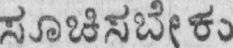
ಸೂಚಿಸಬೇಕು
